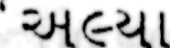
'અલ્યા
